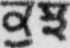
ਕੁਝ
